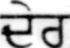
ਦੇਰ
